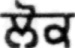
ਲੋਕ
